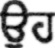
ਉਹ
